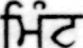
ਮਿੰਟ
